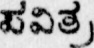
ಪವಿತ್ರ
